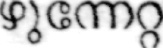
ഴുന്നേറ്റ
